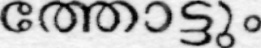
ത്തോട്ടും
